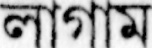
লাগাম
